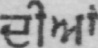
ਦੀਆਂ
